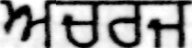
ਅਚਰਜ
